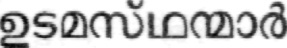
ഉടമസ്ഥന്മാര്‍
